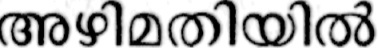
അഴിമതിയില്‍
